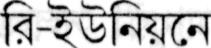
রি-ইউনিয়নে
